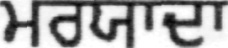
ਮਰਯਾਦਾ
